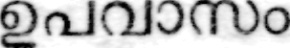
ഉപവാസം
